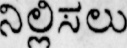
ನಿಲ್ಲಿಸಲು
